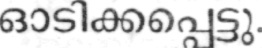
ഓടിക്കപ്പെട്ടു.
